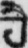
ਹੈ
